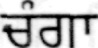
ਚੰਗਾ
